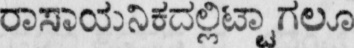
ರಾಸಾಯನಿಕದಲ್ಲಿಟ್ಟಾಗಲೂ
